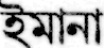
ইমানা
